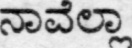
ನಾವೆಲ್ಲಾ
